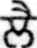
ਲੈ
